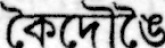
কৈদৌঙৈ
